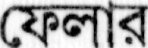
ফেলার
